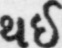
થઈ
